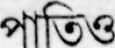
পাতিও
